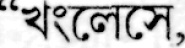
“খংলেসে,
